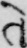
તે
